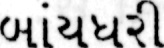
બાંયધરી
